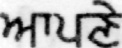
ਆਪਣੇ
